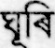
ঘূৰি
